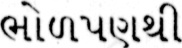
ભોળપણથી
